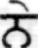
ਨੇ
